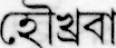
হৌখ্রবা
